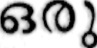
ഒരു
